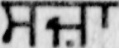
ਸਜ਼ਾ
